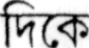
দিকে
